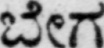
ಬೇಗ
